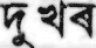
দুখৰ
